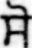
ਸੋ
